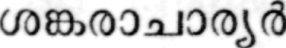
ശങ്കരാചാര്യര്‍
